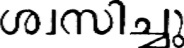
ശ്വസിച്ചു
